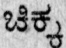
ಚಿಕ್ಕ
